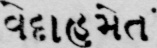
વેદાહમેતં
